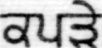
ਕਪੜੇ
